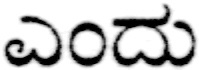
ಎಂದು
